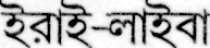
ইরাই-লাইবা
